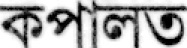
কপালত
